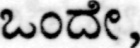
ಒಂದೇ,
